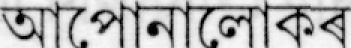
আপোনালোকৰ
